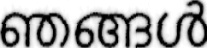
ഞങ്ങള്‍
